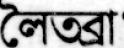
লৈতব্রা
